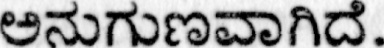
ಅನುಗುಣವಾಗಿದೆ.
